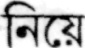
নিয়ে
